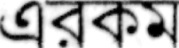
এরকম
